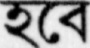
হবে
